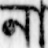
না
